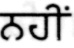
ਨਹੀਂ
